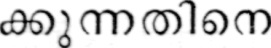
ക്കുന്നതിനെ
